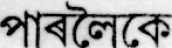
পাৰলৈকে
